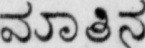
ಮಾತಿನ
